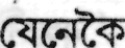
যেনেকৈ
